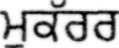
ਮੁਕੱਰਰ
